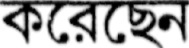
করেছেন
